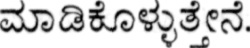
ಮಾಡಿಕೊಳ್ಳುತ್ತೇನೆ.
